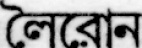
লৈরোন
